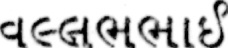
વલ્લભભાઈ
